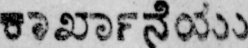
ಕಾರ್ಖಾನೆಯು
